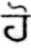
ਹੋ
